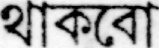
থাকবো
